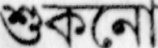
শুকনো
